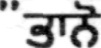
''ਭਾਨੋ
